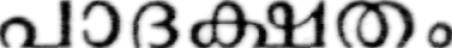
പാദക്ഷതം
